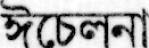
ঈচেলনা
